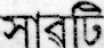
সাৱটি
